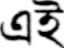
এই
